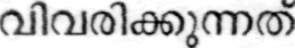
വിവരിക്കുന്നത്
